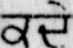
ਕਦੇ
